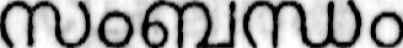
സംബന്ധം
